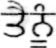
ਤੈਨੂੰ
